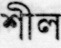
শীল
